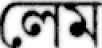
লেম
